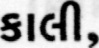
કાલી,
